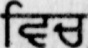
ਵਿਚ
